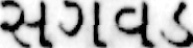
સગવડ
